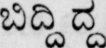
ಬಿದ್ದಿದ್ದ
